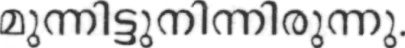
മുന്നിട്ടുനിന്നിരുന്നു.
